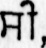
ਸੀ,
